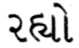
રહ્યો
